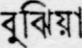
বুঝিয়া
